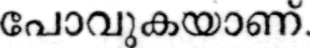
പോവുകയാണ്.
